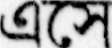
এসে
